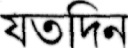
যতদিন
